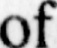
of
